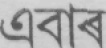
এবাৰ
